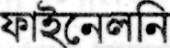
ফাইনেলনি
